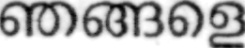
ഞങ്ങളെ
